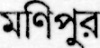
মণিপুর
